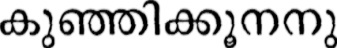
കുഞ്ഞിക്കൂനനു
